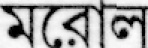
মরোল
